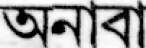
অনাবা
